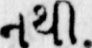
નથી.
